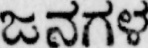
ಜನಗಳ
